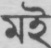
মই
